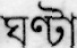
ঘণ্টা
